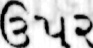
ઉપર
